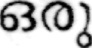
ഒരു
